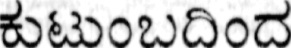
ಕುಟುಂಬದಿಂದ
